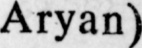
Aryan)
